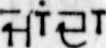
ਜਾਂਦਾ
